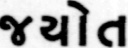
જ્યોત
